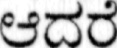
ಆದರೆ
